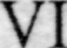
VI
